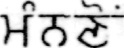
ਮੰਨਣੋਂ
